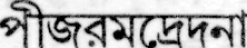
পীজরমদ্রেদনা
